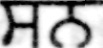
ਸਨ
